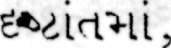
દષ્ટાંતમાં,
